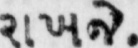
રાખજે.
